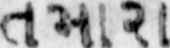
તમારા
